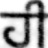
ਹੀ
